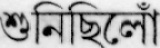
শুনিছিলোঁ
